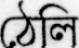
ঠেলি
